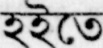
হইতে
